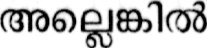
അല്ലെങ്കില്‍
